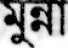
মু্ন্না
